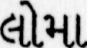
લોમા
